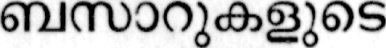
ബസാറുകളുടെ
